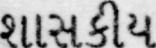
શાસકીય
